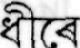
ধীৰে
